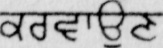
ਕਰਵਾਉਣ
